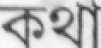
কথা
